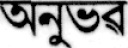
অনুভৱ
